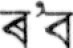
ৰ'ব
